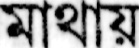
মাথার
